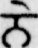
ਨੇ
